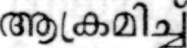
ആക്രമിച്ച്
